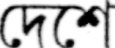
দেশে
